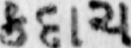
કદાચ
